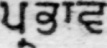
ਪ੍ਰਭਾਵ
